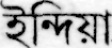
ইন্দয়া
